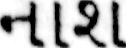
નાશ
